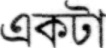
একটা
